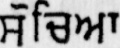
ਸੋਚਿਆ
